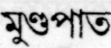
মুণ্ডপাত
